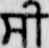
ਸੀ
